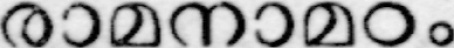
രാമനാമഠം
